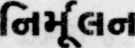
નિર્મૂલન
